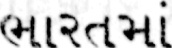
ભારતમાં
